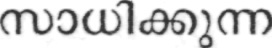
സാധിക്കുന്ന
